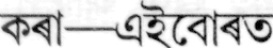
কৰা-এইবোৰত
